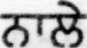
ਨਾਲੇ
